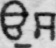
ਉਸ
